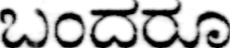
ಬಂದರೂ
